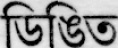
ডিঙিত
